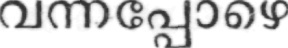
വന്നപ്പോഴെ
